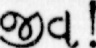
જીવ!
